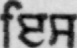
ਇਸ
